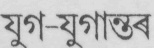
যুগ-যুগান্তৰ
